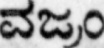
ವಜ್ರಂ
